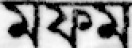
মফম
